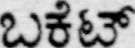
ಬಕೆಟ್
